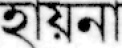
হায়না
